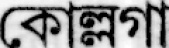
কোল্লগা
